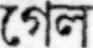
গেল
